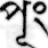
পূং
